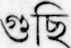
গুছি
